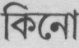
কিনো
